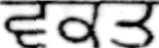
ਵਕਤ
